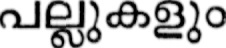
പല്ലുകളും
